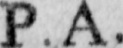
P.A.
